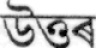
উত্তৰ
